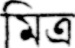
মিত্র
